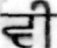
ਵੀ
